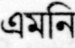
এমনি
